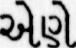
એણે
